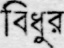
বিধুর
